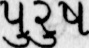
પુરુષ
